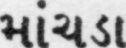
માંચડા
